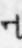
ન
